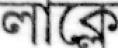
লাক্লে
